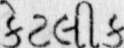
કેટલીક
